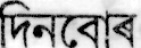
দিনবোৰ
